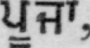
ਪੂਜਾ,
